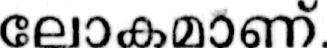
ലോകമാണ്.
